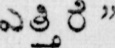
ಎತ್ತಿರೆ”
